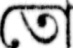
তো
